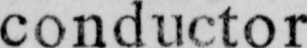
conductor
